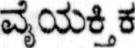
ವೈಯಕ್ತಿಕ
